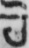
ਹੋ
